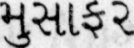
મુસાફર
